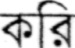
করি
